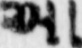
આ
